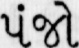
પંજો
